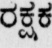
ರಕ್ಷಕ
